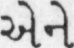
એને
